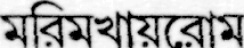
মরিমখায়রোম
